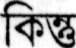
কিন্তু
